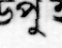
উপু
